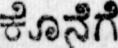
ಕೊನೆಗೆ
